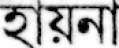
হায়না
